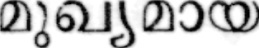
മുഖ്യമായ
